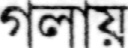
গলায়
